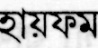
হায়ফম
